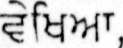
ਵੇਖਿਆ,
